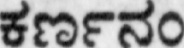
ಕರ್ಣನಂ
